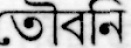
তৌবনি
